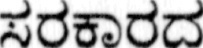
ಸರಕಾರದ
